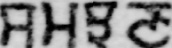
ਸਮਝਣ
